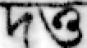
দত্ত
